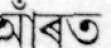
আঁৰত
